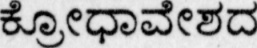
ಕ್ರೋಧಾವೇಶದ
